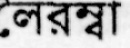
লৈরম্বা
